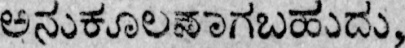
ಅನುಕೂಲವಾಗಬಹುದು,
